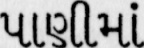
પાણીમાં
